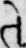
તે
